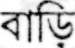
বাড়ি
